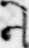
ને
